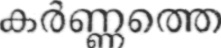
കര്‍ണ്ണത്തെ
